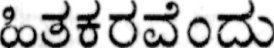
ಹಿತಕರವೆಂದು
